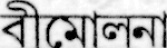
বীমোলনা
